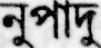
নুপাদু
